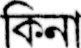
কিনা
